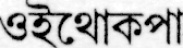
ওইথোকপা
